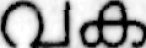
വക
